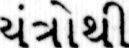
યંત્રોથી
